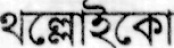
থল্লোইকো
